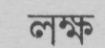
লক্ষ
